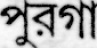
পুরগা
